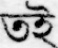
তই
